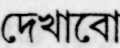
দেখাবো
